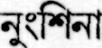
নুংশিনা
